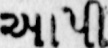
આપી
